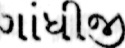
ગાંધીજી
